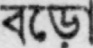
বড়ো
